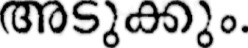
അടുക്കും.
